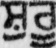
ਸ਼ੁਰੂ
